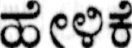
ಹೇಳಿಕೆ
